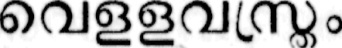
വെളളവസ്ത്രം
